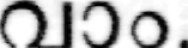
വാം.
